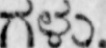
ಗಳು.
